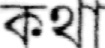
কথা
